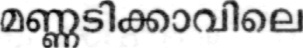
മണ്ണടിക്കാവിലെ
